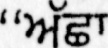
''ਅੱਛਾ
